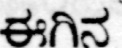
ಈಗಿನ
